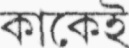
কাকেই
